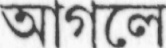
আগলে
